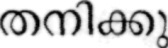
തനിക്കു
